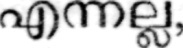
എന്നല്ല,
